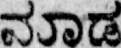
ಮಾಡ
